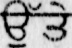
ਉੱਤੇ
